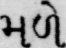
મળે
